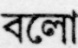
বলো
